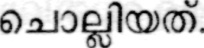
ചൊല്ലിയത്.
